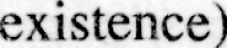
existence)
